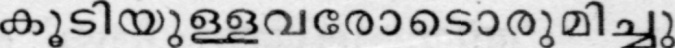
കൂടിയുള്ളവരോടൊരുമിച്ചു
